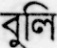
বুলি
